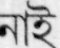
নাই
